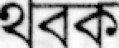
থবক
